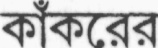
কাঁকরের
